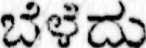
ಬೆಳೆದು
